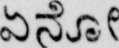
ಏನೋ
